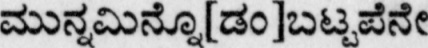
ಮುನ್ನಮಿನ್ನೊ[ಡಂ]ಬಟ್ಟಪೆನೇ
